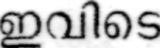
ഇവിടെ
